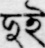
দুই
